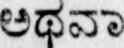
ಅಥವಾ
